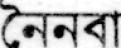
নৈনবা
